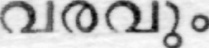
വരവും
